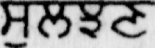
ਸੁਲਝਣ
